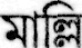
মাল্লি
